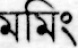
মমিং
